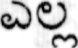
ಎಲ್ಲ
